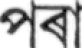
পৰা
